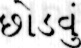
છોડવું
